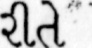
રીતે
